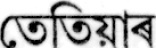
তেতিয়াৰ
